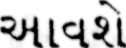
આવશે
